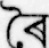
ৰৈ
